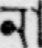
না
